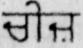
ਚੀਜ਼
